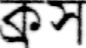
ক্রস
